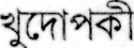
খুদোপকী
